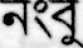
নংবু
